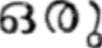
ഒരു
